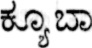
ಕ್ಯೂಬಾ
